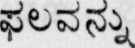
ಫಲವನ್ನು
